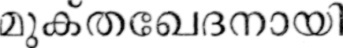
മുക്തഖേദനായി
